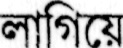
লাগিয়ে
